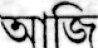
আজি
